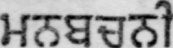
ਮਨਬਚਨੀ
